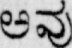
ಅವು
